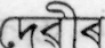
দেৱীৰ
